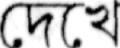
দেখে
